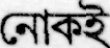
নোকই
